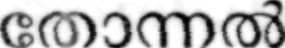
തോന്നല്‍
